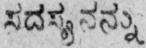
ಸದಸ್ಯನನ್ನು
